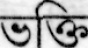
ভক্তি
